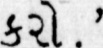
કરો.'
